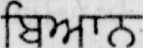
ਬਿਆਨ
